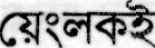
য়েংলকই
